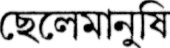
ছেলেমানুষি
